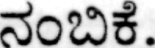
ನಂಬಿಕೆ.
